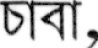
চাবা,
